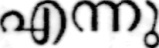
എന്നു
